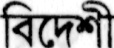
বিদেশী
